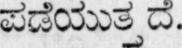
ಪಡೆಯುತ್ತದೆ.
